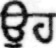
ਉਹ
